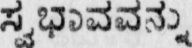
ಸ್ವಭಾವವನ್ನು
